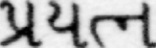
પ્રયત્ન
